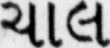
ચાલ
